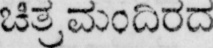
ಚಿತ್ರಮಂದಿರದ
